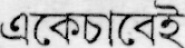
একেচাবেই
